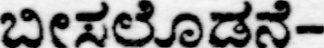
ಬೀಸಲೊಡನೆ-
